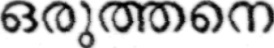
ഒരുത്തനെ
